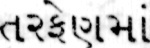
તરફેણમાં
